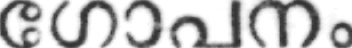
ഗോപനം
